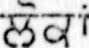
ਲੋਕਾਂ
